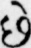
છે
